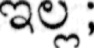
ಇಲ್ಲ;
